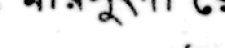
থম্মোয়নুংদা
